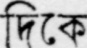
দিকে
